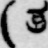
(ತ
